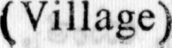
(Village)
